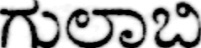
ಗುಲಾಬಿ
